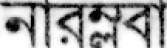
নারম্লবা
